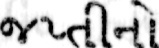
જપ્તીનો
